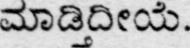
ಮಾಡ್ತಿದೀಯೆ.
